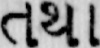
તથા
